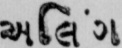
અલિંગ
